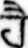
ਹੈ
